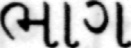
ભાગ
